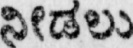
ನೀಡಲು
